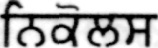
ਨਿਕੋਲਸ
